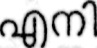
എനി
